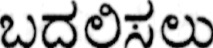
ಬದಲಿಸಲು
